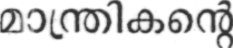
മാന്ത്രികന്റെ
